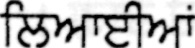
ਲਿਆਈਆਂ
